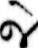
જે
